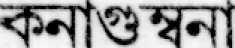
কনাগুম্বনা
